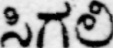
ಸಿಗಲಿ
